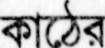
কাঠের
